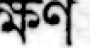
ক্ষণ
